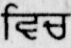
ਵਿਚ
